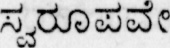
ಸ್ವರೂಪವೇ
